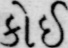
કોઈ
